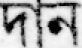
দান
